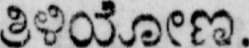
ತಿಳಿಯೋಣ.
